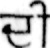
ਦੀ
